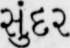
સુંદર
